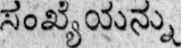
ಸಂಖ್ಯೆಯನ್ನು
